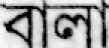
বালা
